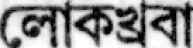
লোকখ্রবা
